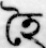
হৈ
